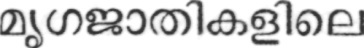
മൃഗജാതികളിലെ
